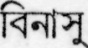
বিনাসু
